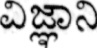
ವಿಜ್ಞಾನಿ
